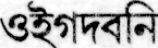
ওইগদবনি
